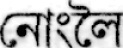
নোংলৈ
